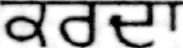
ਕਰਦਾ
